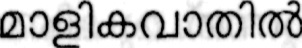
മാളികവാതില്‍
